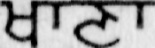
ਖਾਣਾ
